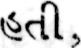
હતી,
